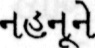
નહનૂને
